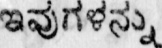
ಇವುಗಳನ್ನು
